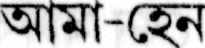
আমা-হেন
